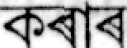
কৰাৰ
